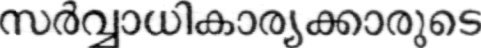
സര്‍വ്വാധികാര്യക്കാരുടെ
